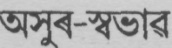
অসুৰ-স্বভাৱ
